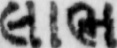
લાભ
